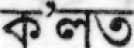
ক'লত
